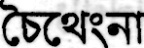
চৈথেংনা
